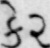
કેર
